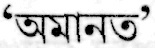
‘অমানত’
